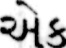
એક
